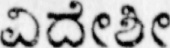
ವಿದೇಶೀ
